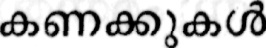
കണക്കുകള്‍
